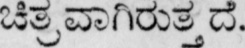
ಚಿತ್ರವಾಗಿರುತ್ತದೆ.
